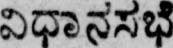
ವಿಧಾನಸಭೆ
